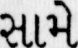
સામે
